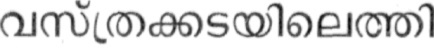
വസ്ത്രക്കടയിലെത്തി
